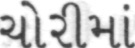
ચોરીમાં
